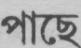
পাছে
